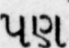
પણ
